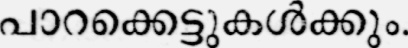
പാറക്കെട്ടുകള്‍ക്കും.
